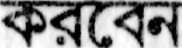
করবেন
